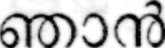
ഞാന്‍
